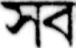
সব
